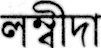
লম্বীদা
